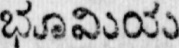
ಭೂಮಿಯ
